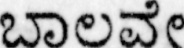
ಬಾಲವೇ
